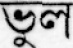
ভুল
